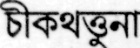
চীকথক্তুনা
